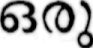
ഒരു
